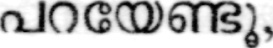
പറയേണ്ടൂ,
